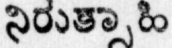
ನಿರುತ್ಸಾಹಿ
